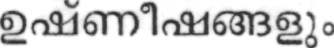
ഉഷ്ണീഷങ്ങളും
